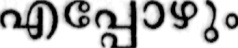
എപ്പോഴും
